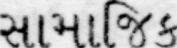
સામાજિક
